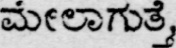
ಮೇಲಾಗುತ್ತೆ,
